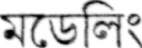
মডেলিং
